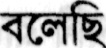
বলেছি
